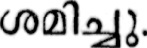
ശമിച്ചു.
